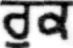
ਰੁਕ
